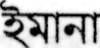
ইমানা
